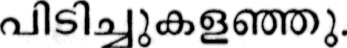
പിടിച്ചുകളഞ്ഞു.
